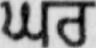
ਘਰ
